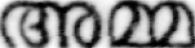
അമ്മ
